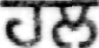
ਹਲ
